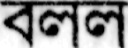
বলল
